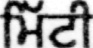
ਮਿੱਟੀ
